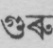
গুৰু
